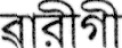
ৱারীগী
